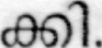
ക്കി.
